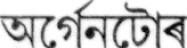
অর্গেনটোৰ
